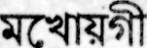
মখোয়গী
